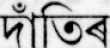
দাঁতিৰ
